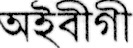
অইবীগী
